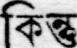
কিন্তু
